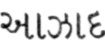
આઝાદ
